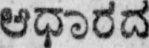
ಆಧಾರದ
